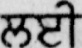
ਲਈ
